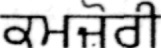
ਕਮਜ਼ੋਰੀ
